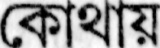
কোথায়
